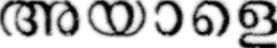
അയാളെ
